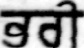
ਭਰੀ
